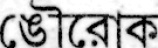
ঙৌরোক
